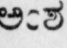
ಅಂಶ
